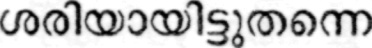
ശരിയായിട്ടുതന്നെ
